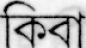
কিবা
